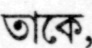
তাকে,
